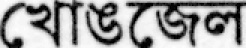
খোঙজেল
